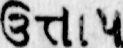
ઉત્તાપ
